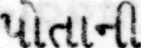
પોતાની
